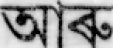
আৰু
